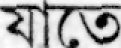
যাতে
